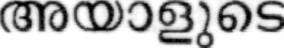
അയാളുടെ
